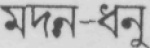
মদন-ধনু
